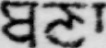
ਬਣਾ
